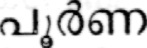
പൂര്‍ണ
